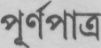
পূৰ্ণপাত্র
